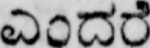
ಎಂದರೆ
